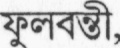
ফুলবন্তী,
